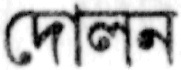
দোলন
